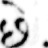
છે.
